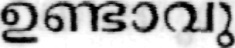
ഉണ്ടാവു
